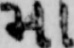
મા
